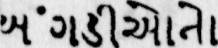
બંગડીઓનો
